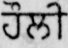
ਹੌਲੀ
